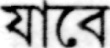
যাবে
